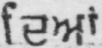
ਦਿਆਂ
